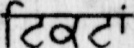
ਟਿਕਟਾਂ
